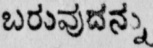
ಬರುವುದನ್ನು
